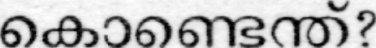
കൊണ്ടെന്ത്?
